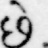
છે.
